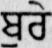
ਬੁਰੇ
